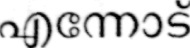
എന്നോട്
